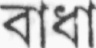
বাধা
